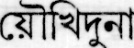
য়ৌখিদুনা
